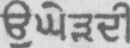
ਉਘੇੜਦੀ
